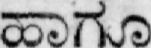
ಹಾಗೂ
